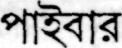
পাইবার
